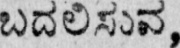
ಬದಲಿಸುವ,
